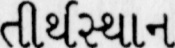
તીર્થસ્થાન
